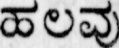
ಹಲವು
